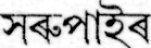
সৰুপাইৰ
